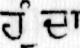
ਹੁੰਦਾ
